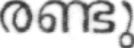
രണ്ടു
